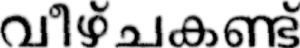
വീഴ്ചകണ്ട്
